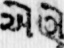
એણે
